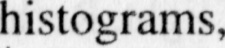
histograms,
